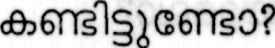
കണ്ടിട്ടുണ്ടോ?
